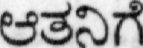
ಆತನಿಗೆ
